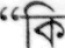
"কি
